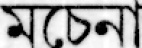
মচেনা
